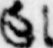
હા
